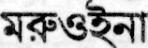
মরুওইনা
